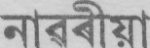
নাৱৰীয়া
